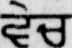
ਵੇਚ
